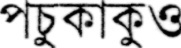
পচুকাকুও
